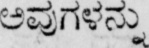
ಅವುಗಳನ್ನು
